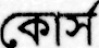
কোর্স
